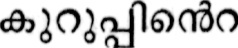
കുറുപ്പിന്റെ
